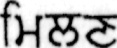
ਮਿਲਣ
